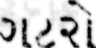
ગટરો
